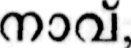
നാവ്,
